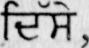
ਦਿੱਸੇ,
